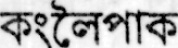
কংলৈপাক
